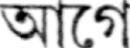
আগে
